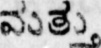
ಮತ್ತು
